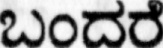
ಬಂದರೆ
